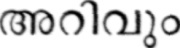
അറിവും
